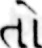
તો
